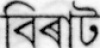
বিৰাট
